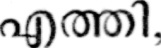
എത്തി,
